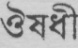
ঔষধী
